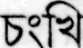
চংখি
